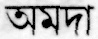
অমদা
